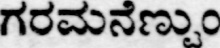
ಗರಮನೆಣ್ಟುಂ
